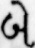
બે
